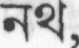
নথ,
